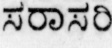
ಸರಾಸರಿ
